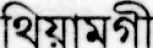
থিয়ামগী
